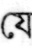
যে
